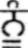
ਨੂੰ
